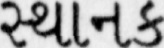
સ્થાનક
